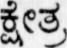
ಕ್ಷೇತ್ರ
